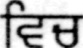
ਵਿਚ
